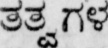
ತತ್ವಗಳ
